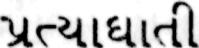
પ્રત્યાઘાતી
